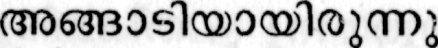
അങ്ങാടിയായിരുന്നു
